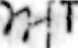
ਆ
